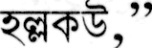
হল্লকউ,”
